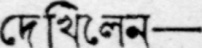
দেখিলেন—
